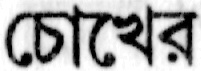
চোখের
